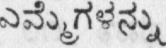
ಎಮ್ಮೆಗಳನ್ನು
